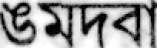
ঙমদবা
